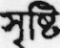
সৃষ্টি
